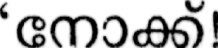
'നോക്ക്!
